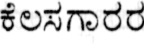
ಕೆಲಸಗಾರರ
